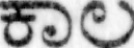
ಕಾಲ
